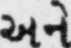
અને
